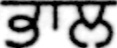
ਭਾਲ
